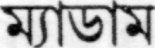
ম্যাডাম
